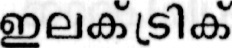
ഇലക്ട്രിക്
